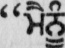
''ਮੈਨੂੰ
